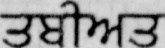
ਤਬੀਅਤ
